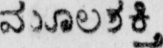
ಮೂಲಶಕ್ತಿ
